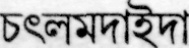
চৎলমদাইদা
